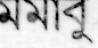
মমাবু
